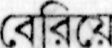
বেরিয়ে
